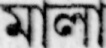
মালা
